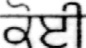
ਕੋਈ
